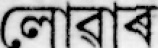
লোৱাৰ
